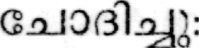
ചോദിച്ചു:
